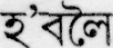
হ'বলৈ
